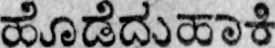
ಹೊಡೆದುಹಾಕಿ
